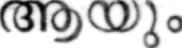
ആയും
